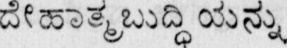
ದೇಹಾತ್ಮಬುದ್ಧಿಯನ್ನು
